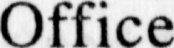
Office
